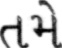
તમે
